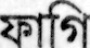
ফাগি
